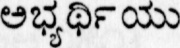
ಅಭ್ಯರ್ಥಿಯು
